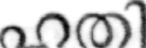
ഹതി
